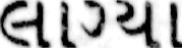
લાગ્યા
